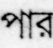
পার
